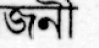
রজনী
